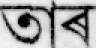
তাৰ
